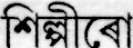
শিল্পীৰো
